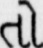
તો
